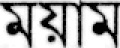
ময়াম
